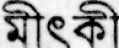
মীৎকী
